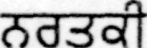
ਨਰਤਕੀ
